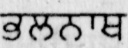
ਭਲਨਾਥ
